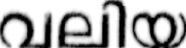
വലിയ
